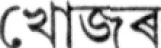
খোজৰ
